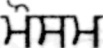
ਮੌਸਮ
